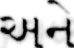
અને
